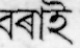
বৰাই
